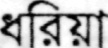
ধরিয়া
